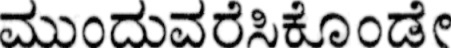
ಮುಂದುವರೆಸಿಕೊಂಡೇ
